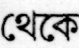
থেকে
